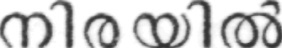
നിരയില്‍
